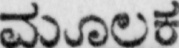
ಮೂಲಕ
